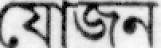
যোজন
